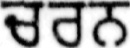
ਚਰਨ
